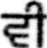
ਵੀ
